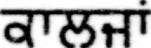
ਕਾਲਜਾਂ
